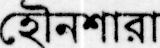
হৌনশারা
